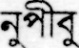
নুপীবু
